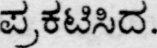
ಪ್ರಕಟಿಸಿದ.
